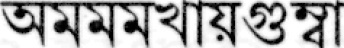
অমমমখায়গুম্বা
